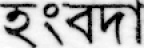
হংবদা
